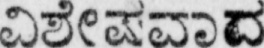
ವಿಶೇಷವಾದ
